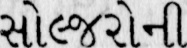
સોલ્જરોની
